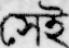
সেই
